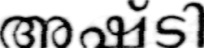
അഷ്ടി
